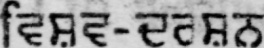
ਵਿਸ਼ਵ-ਦਰਸ਼ਨ
